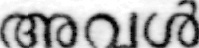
അവള്‍
